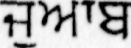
ਜੁਆਬ
